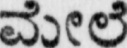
ಮೇಲೆ
